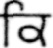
ਕਿ
